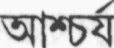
আশ্চর্য
